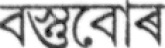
বস্তুবোৰ
